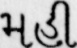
મહી
